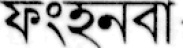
ফংহনবা
